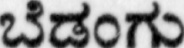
ಬೆಡಂಗು
